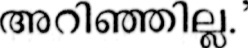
അറിഞ്ഞില്ല.’
